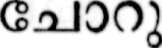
ചോറു
